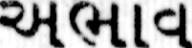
અભાવ
